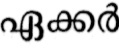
ഏക്കര്‍
